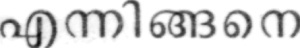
എന്നിങ്ങനെ
